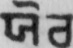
ਯੋਰ
